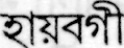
হায়বগী
